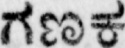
ಗಣಕ
